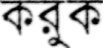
করুক
